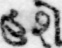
હશે
